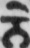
ਨੇ
